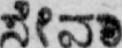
ಸೇವಾ
